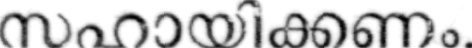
സഹായിക്കണം.
